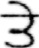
ਤੇ
